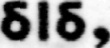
ઠાઠ,
